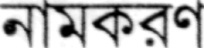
নামকরণ
